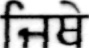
ਜਿਥੇ
